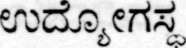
ಉದ್ಯೋಗಸ್ಥ
